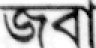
জবা
